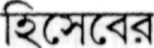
হিসেবের
